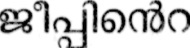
ജീപ്പിന്റെ
